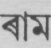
ৰাম
